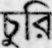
চুরি
